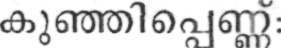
കുഞ്ഞിപ്പെണ്ണ്:
